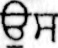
ਉਸ
